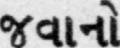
જવાનો
